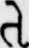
તે
